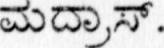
ಮದ್ರಾಸ್.
